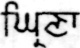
ਘ੍ਰਿਣਾ
